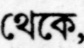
থেকে,
